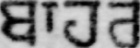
ਬਾਹਰ
